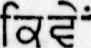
ਕਿਵੇਂ
